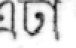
এটা
